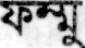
ফম্মু
